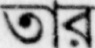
তার
